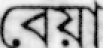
বেয়া
